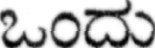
ಒಂದು
